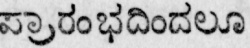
ಪ್ರಾರಂಭದಿಂದಲೂ
